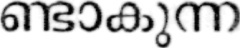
ണ്ടാകുന്ന
